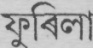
ফুৰিলা
